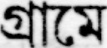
গ্রামে
